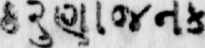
કરુણાજનક
